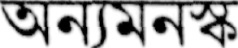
অন্যমনস্ক
